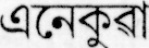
এনেকুৱা
